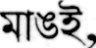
মাঙই,
